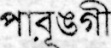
পাবুঙগী
